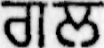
ਗਲ
